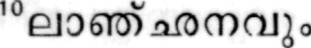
10ലാഞ്ഛനവും
